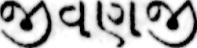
જીવણજી
